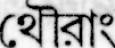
থৌরাং
